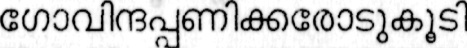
ഗോവിന്ദപ്പണിക്കരോടുകൂടി
